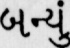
બન્યું
